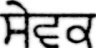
ਸੇਵਕ
